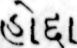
હોદ્દા
